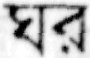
ঘর
